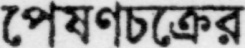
পেষণচক্রের
